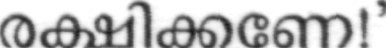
രക്ഷിക്കണേ!’
